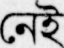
নেই
